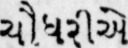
ચૌધરીએ
